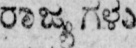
ರಾಜ್ಯಗಳು
